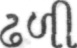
ઢળી
